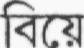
বিয়ে
